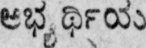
ಅಭ್ಯರ್ಥಿಯ
